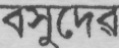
বসুদেৱ
